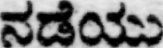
ನಡೆಯು
